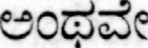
ಅಂಥವೇ
